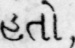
હતો,
